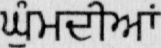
ਘੁੰਮਦੀਆਂ
